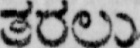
ತರಲು
